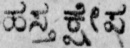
ಹಸ್ತಕ್ಷೇಪ
